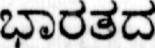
ಭಾರತದ
